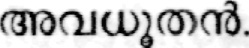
അവധൂതന്‍.
